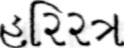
હરિરત્ર
